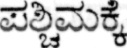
ಪಶ್ಚಿಮಕ್ಕೆ
